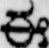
ಈ
